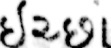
ઇચ્છા
